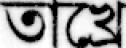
তাখ্রে
